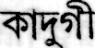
কাদুগী
